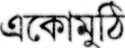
একোমুঠি
